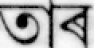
তাৰ
